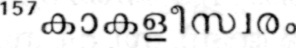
157കാകളീസ്വരം
